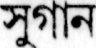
সুগান
